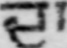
ਦਾ
